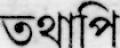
তথাপি
